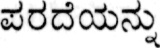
ಪರದೆಯನ್ನು
